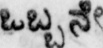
ಒಬ್ಬನೇ
